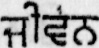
ਜੀਵਨ
